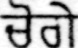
ਚੋਗੇ
